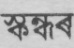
স্কন্ধৰ
